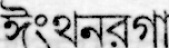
ঈংথনরগা
